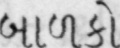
બાળકો
